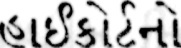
હાઈકોર્ટનો
